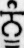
ਨੂੰ
